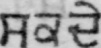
ਸਕਦੇ
